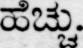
ಹೆಚ್ಚು.
